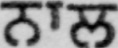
ਨਾਲ
